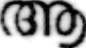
ആ
